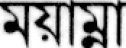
ময়াম্না
